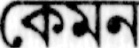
কেমন
